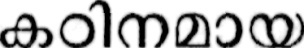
കഠിനമായ
